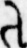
તે
